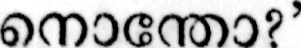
നൊന്തോ?'
